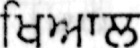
ਖਿਆਲ
